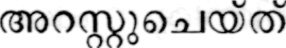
അറസ്റ്റുചെയ്ത്
